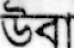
উবা
